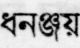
ধনঞ্জয়
